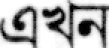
এখন
